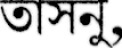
তাসনু,
